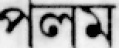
পলম
